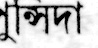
পুন্সিদা
